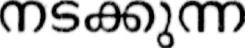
നടക്കുന്ന
